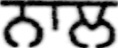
ਨਾਲ
